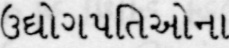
ઉદ્યોગપતિઓના
